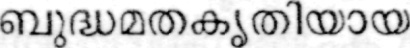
ബുദ്ധമതകൃതിയായ
